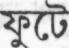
ফুটে
